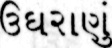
ઉઘરાણું
